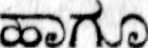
ಹಾಗೂ
